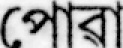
পোৱা
